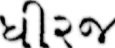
ધીરજ
